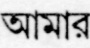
আমার
